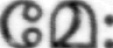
മേ:
